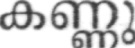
കണ്ണു
